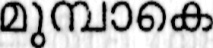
മുമ്പാകെ
